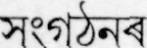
সংগঠনৰ
